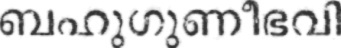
ബഹുഗുണീഭവി
